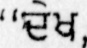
''ਦੇਖ,
